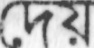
দেয়
